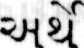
અર્થે
